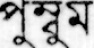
পুম্বুম
